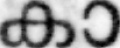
കാ
